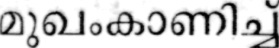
മുഖംകാണിച്ച്
